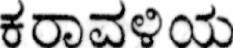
ಕರಾವಳಿಯ
